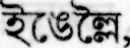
ইঙেল্লৈ,
